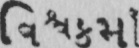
વિશ્વકર્મા
